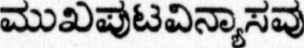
ಮುಖಪುಟವಿನ್ಯಾಸವು
